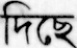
দিছে
